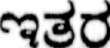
ಇತರ
